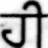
ਹੀ
